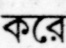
করে
